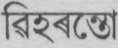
ৱিহৰন্তো
